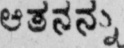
ಆತನನ್ನು
